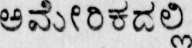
ಅಮೇರಿಕದಲ್ಲಿ
